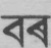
বৰ
